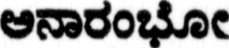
ಅನಾರ೦ಭೋ
